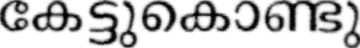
കേട്ടുകൊണ്ടു
